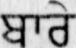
ਬਾਰੇ
